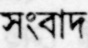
সংবাদ
